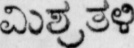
ಮಿಶ್ರತಳಿ
